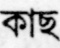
কাছ
